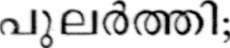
പുലര്‍ത്തി;
